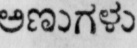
ಅಣುಗಳು
